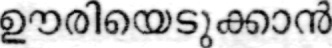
ഊരിയെടുക്കാന്‍
